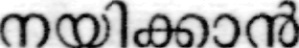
നയിക്കാന്‍
